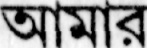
আমার
